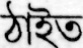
ঠাইত
